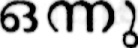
ഒന്നു
